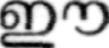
ഈ
